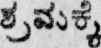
ಶ್ರಮಕ್ಕೆ
